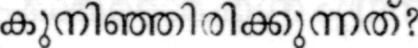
കുനിഞ്ഞിരിക്കുന്നത്?
